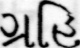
ગ્રહિ
